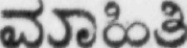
ಮಾಹಿತಿ
